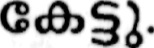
കേട്ടു.
